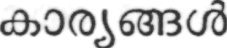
കാര്യങ്ങള്‍
